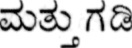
ಮತ್ತುಗಡಿ
